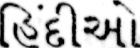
હિંદીઓ
